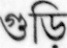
গুড়ি
